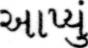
આપ્યું
